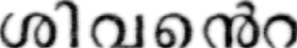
ശിവന്റെ
